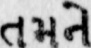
તમને
